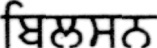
ਬਿਲਸਨ
